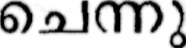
ചെന്നു
